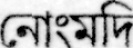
নোংমদি
